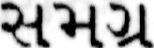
સમગ્ર
